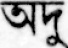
অদু
